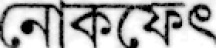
নোকফেৎ
